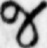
જ
